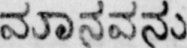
ಮಾನವನು
